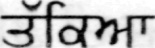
ਤੱਕਿਆ
